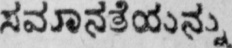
ಸಮಾನತೆಯನ್ನು
